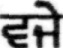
ਵਜੇ
